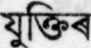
যুক্তিৰ
